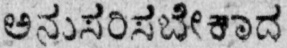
ಅನುಸರಿಸಬೇಕಾದ
